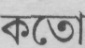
কতো
